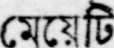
মেয়েটি
